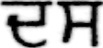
ਦਸ
